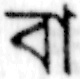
বা
